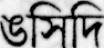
ঙসিদি
